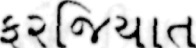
ફરજિયાત
